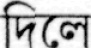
দিলে
